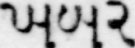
ખબર
